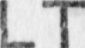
LT
